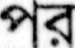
পর
